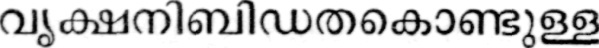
വൃക്ഷനിബിഡതകൊണ്ടുള്ള
